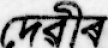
দেৱীৰ
